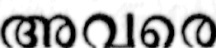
അവരെ
